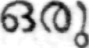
ഒരു
